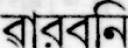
ৱারবনি
